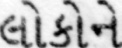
લોકોને
